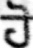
ਹੋ
